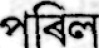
পৰিল
